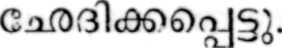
ഛേദിക്കപ്പെട്ടു.
